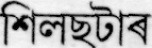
শিলছটাৰ
